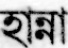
হান্না
